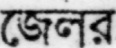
জেলর
